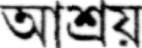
আশ্রয়
